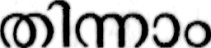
തിന്നാം
